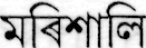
মৰিশালি
